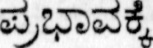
ಪ್ರಭಾವಕ್ಕೆ
